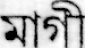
মাগী
